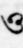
ও
